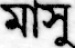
মাসু
